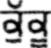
ਕੁੱਕੂ
